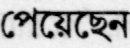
পেয়েছেন
